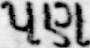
પણ
